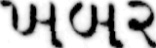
ખબર
